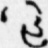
'હે
